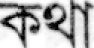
কথা
